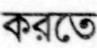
করতে
